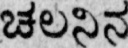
ಚಲನಿನ
